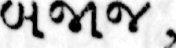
બજાજ,
